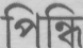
পিন্ধি
